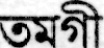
তমগী
